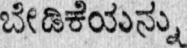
ಬೇಡಿಕೆಯನ್ನು
